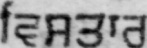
ਵਿਸਤਾਰ
